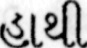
હાથી
